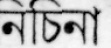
নিচিনা
